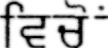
ਵਿਚੋਂ
